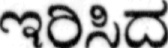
ಇರಿಸಿದ
